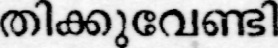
തിക്കുവേണ്ടി
